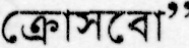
ক্রোসবো”
